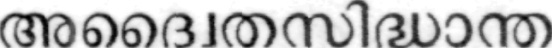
അദ്വൈതസിദ്ധാന്ത
